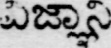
ವಿಜ್ಞಾನಿ
